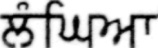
ਲੰਘਿਆ
